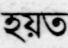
হয়ত
